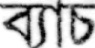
ব্যাচ
